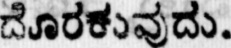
ದೊರಕುವುದು.
